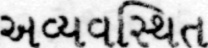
અવ્યવસ્થિત
